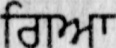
ਗਿਆ
